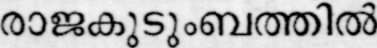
രാജകുടുംബത്തില്‍
